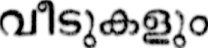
വീടുകളും
